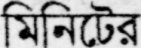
মিনিটের
